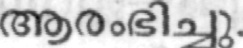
ആരംഭിച്ചു.
